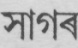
সাগৰ
